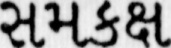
સમકક્ષ
